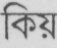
কিয়
